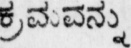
ಕ್ರಮವನ್ನು
